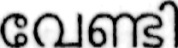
വേണ്ടി
